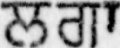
ਲਗਾ
